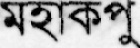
মহাকপু
